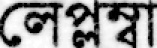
লেপ্লম্বা
